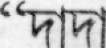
"দাদা
